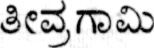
ತೀವ್ರಗಾಮಿ
